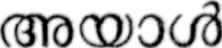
അയാള്‍
